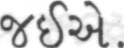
જઈએ.
